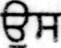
ਉਸ
